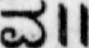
ವ||
